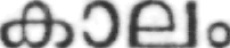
കാലം
